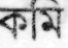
কমি
